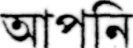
আপনি
